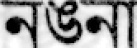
নঙনা
